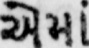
એમાં
